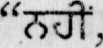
''ਨਹੀਂ,
